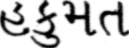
હકુમત
